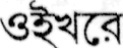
ওইখরে
